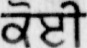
ਕੋਈ
